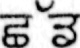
ਛੱਡ
